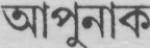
আপুনাক
